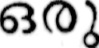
ഒരു
